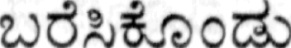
ಬರೆಸಿಕೊಂಡು
